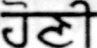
ਹੋਣੀ
